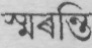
স্মৰন্তি
